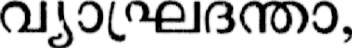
വ്യാഘ്രദന്താ,
